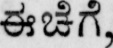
ಈಚೆಗೆ,
